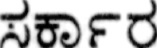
ಸರ್ಕಾರ
